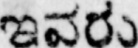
ಇವರು
